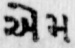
એમ
